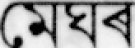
মেঘৰ
